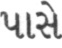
પાસે
